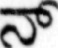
ನ್
